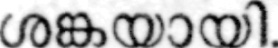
ശങ്കയായി.
